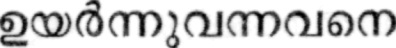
ഉയര്‍ന്നുവന്നവനെ
